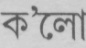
ক'লো
